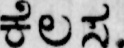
ಕೆಲಸ.
